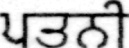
ਪਤਨੀ
